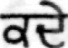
ਕਦੇ
